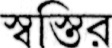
স্বস্তির
